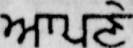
ਆਪਣੇ
